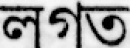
লগত
